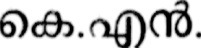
കെ.എന്‍.
